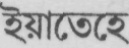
ইয়াতেহে
